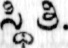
ಸ್ಥಿತಿ.
